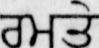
ਰਮਤੇ
